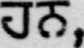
ਹਨ,
